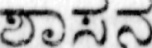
ಶಾಸನ
